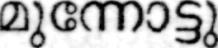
മുന്നോട്ടു
